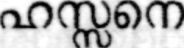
ഹസ്സനെ
